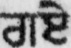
ਗਏ
